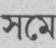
সমে
